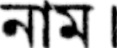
নাম।
